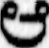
ಆ
